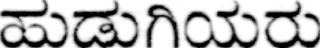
ಹುಡುಗಿಯರು
